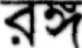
রঙ্গ
